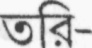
তরি-
